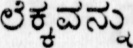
ಲೆಕ್ಕವನ್ನು
